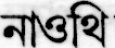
নাওথি
